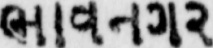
ભાવનગર
